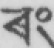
ৰং
